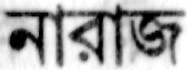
নারাজ
